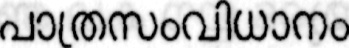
പാത്രസംവിധാനം
